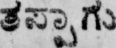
ತಪ್ಪಾಗು
